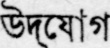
উদ্‌যোগ
